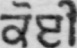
ਕੋਈ
